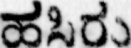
ಹಸಿರು
